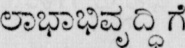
ಲಾಭಾಭಿವೃದ್ಧಿಗೆ
